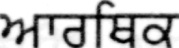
ਆਰਥਿਕ
